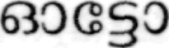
ഓട്ടോ
